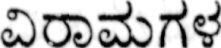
ವಿರಾಮಗಳ
